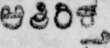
ಅತಿರಿಕ್ತ
